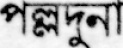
পল্লদুনা
